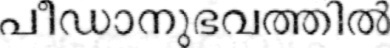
പീഡാനുഭവത്തില്‍
